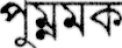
পুম্নমক
